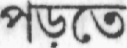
পড়তে
